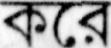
করে
